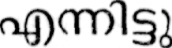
എന്നിട്ടു
